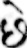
છે
